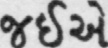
જઈએ
